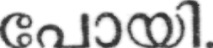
പോയി.
